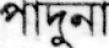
পাদুনা
